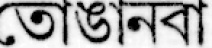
তোঙানবা
